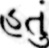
હતું
